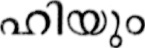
ഹിയും
